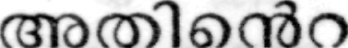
അതിന്റെ
